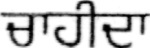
ਚਾਹੀਦਾ
